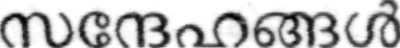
സന്ദേഹങ്ങള്‍
